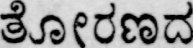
ತೋರಣದ
